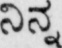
ನಿನ್ನ
